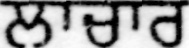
ਲਾਚਾਰ
